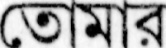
তোমার
